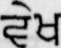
ਵੇਖ
